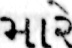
મારે
